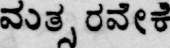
ಮತ್ಸರವೇಕೆ
